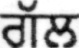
ਗੱਲ
